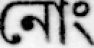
নোং
